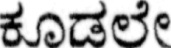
ಕೂಡಲೇ
